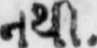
નથી.
